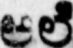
ಅಲೆ
